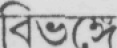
বিভঙ্গে
